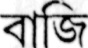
বাজি
